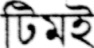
টিমই
